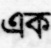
এক
